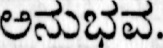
ಅನುಭವ.
